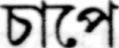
চাপে
